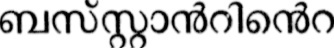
ബസ് സ്റ്റാൻറിൻെറ
